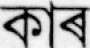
কাৰ
